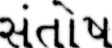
સંતોષ
